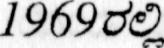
1969ರಲ್ಲಿ
